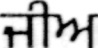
ਜੀਅ
